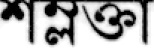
শম্লক্তা
